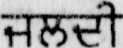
ਜਲਦੀ
